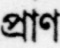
প্রাণ
